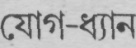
যোগ-ধ্যান
